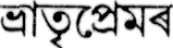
ভ্রাতৃপ্রেমৰ
